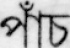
পাঁচ
